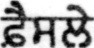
ਫ਼ੈਸਲੇ
